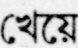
খেয়ে
